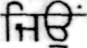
ਜਿਉਂ
